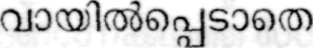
വായില്‍പ്പെടാതെ
